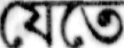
যেতে
